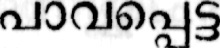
പാവപ്പെട്ട
